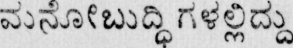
ಮನೋಬುದ್ಧಿಗಳಲ್ಲಿದ್ದು
